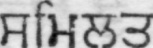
ਸਮਿਲਤ
